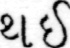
થઈ
